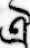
ঐ
